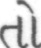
તો
